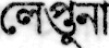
লেপ্তুনা
